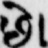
છો?
